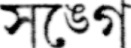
সঙ্গে
